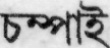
চম্পাই
